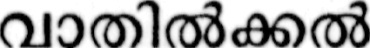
വാതില്‍ക്കല്‍
